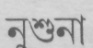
নুশুনা
